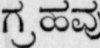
ಗ್ರಹವು
